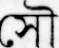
সৌ
